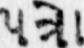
પત્રો
